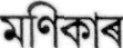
মণিকাৰ
